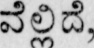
ವೆಲ್ಲಿದೆ,
